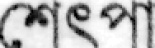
শেৎপা
